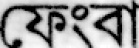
ফেংবা
